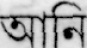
আনি
